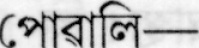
পোৱালি-
